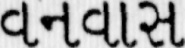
વનવાસ
